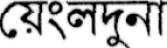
য়েংলদুনা
